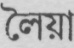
লৈয়া
